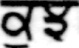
ਕੁਝ
